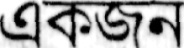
একজন
